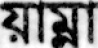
য়াম্না
